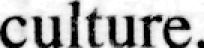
culture.
